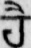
ਹੈ
